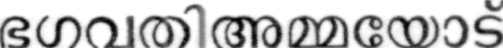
ഭഗവതിഅമ്മയോട്
